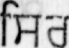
ਸਿਰ
